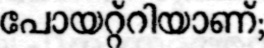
പോയറ്റ്റിയാണ്;
